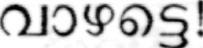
വാഴട്ടെ!
